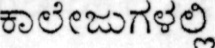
ಕಾಲೇಜುಗಳಲ್ಲಿ
